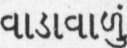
વાડાવાળું
